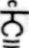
ਨੂੰ
